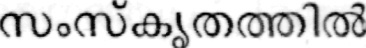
സംസ്കൃതത്തില്‍
